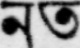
নত
